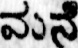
ಮನೆ
